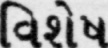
વિશેષ
